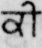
ਕੀ
